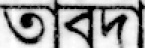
তাবদা
